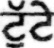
ਟੁੱਟੇ
